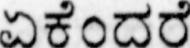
ಏಕೆಂದರೆ
